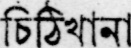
চিঠিখানা
